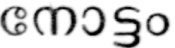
നോട്ടം
